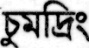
চুমদ্রিং
